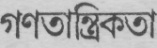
গণতান্ত্ৰিকতা
